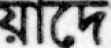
য়াদে
